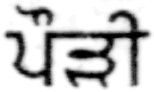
ਪੌੜੀ
